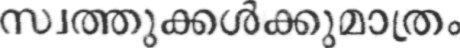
സ്വത്തുക്കള്‍ക്കുമാത്രം
